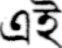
এই
